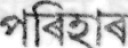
পৰিহাৰ
